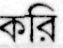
করি
